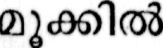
മൂക്കില്‍
